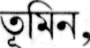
তূমিন,
